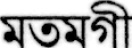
মতমগী
